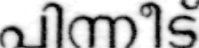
പിന്നീട്
